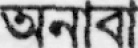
অনাবা
